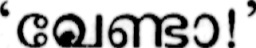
'വേണ്ടാ!'
